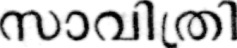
സാവിത്രി
